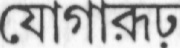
যোগারূঢ়
